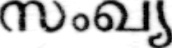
സംഖ്യ
